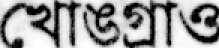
খোঙগ্রাও
